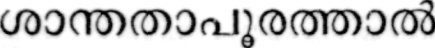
ശാന്തതാപൂരത്താല്‍
